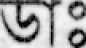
ডাঃ
